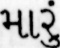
મારું
